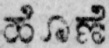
ಹೊಣೆ
